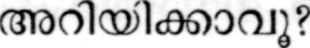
അറിയിക്കാവൂ?
